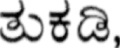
ತುಕಡಿ,
